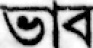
ভাব
